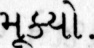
મૂક્યો.
